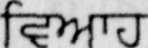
ਵਿਆਹ
